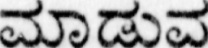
ಮಾಡುವ
